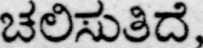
ಚಲಿಸುತಿದೆ,
